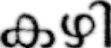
കഴി
